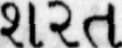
શરત
